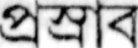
প্রস্রাব
